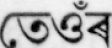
তেওঁৰ
